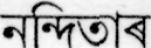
নন্দিতাৰ
